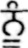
ਨੂੰ
